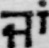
ਜਾਂ
